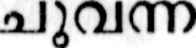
ചുവന്ന
